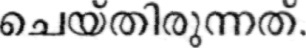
ചെയ്തിരുന്നത്.
